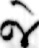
જે
